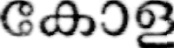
കോള
